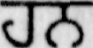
ਹਨ
